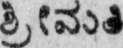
ಶ್ರೀಮತಿ
